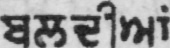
ਬਲਦੀਆਂ
